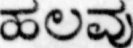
ಹಲವು
